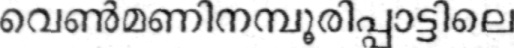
വെണ്‍മണിനമ്പൂരിപ്പാട്ടിലെ
